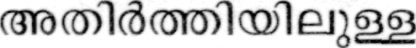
അതിര്‍ത്തിയിലുള്ള
